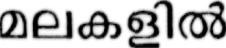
മലകളില്‍
